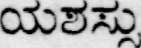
ಯಶಸ್ಸು
